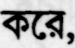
করে,
